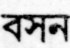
বসন
